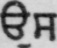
ਉਸ
